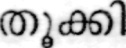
തൂക്കി
